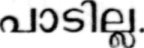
പാടില്ല.
